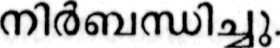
നിര്‍ബന്ധിച്ചു.
